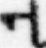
ન
